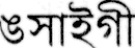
ঙসাইগী
